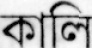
কালি
